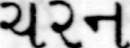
ચરન
